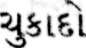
ચુકાદો
